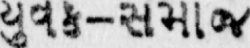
યુવક-સમાજ
